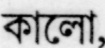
কালো,
